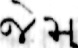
જેમ
